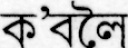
ক'বলৈ
